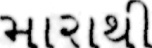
મારાથી
